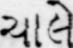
ચાલે
